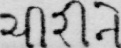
ચીરીને
